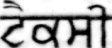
ਟੈਕਸੀ
